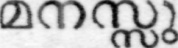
മനസ്സു
